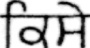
ਕਿਸੇ
